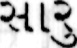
સારુ
